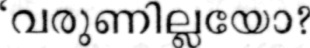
'വരുണില്ലയോ?
